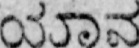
ಯಾವ
